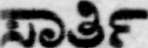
ಸಾರ್ತಿ
